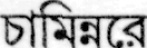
চামিন্নরে
